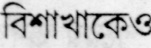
বিশাখাকেও
